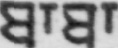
ਬਾਬਾ
